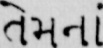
તેમનાં
